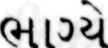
ભાગ્યે
